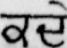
ਕਦੇ
